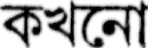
কখনো
